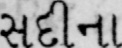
સદીના
